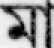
মা
